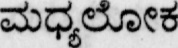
ಮಧ್ಯಲೋಕ
